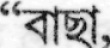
"বাছা,
